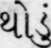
થોડું
